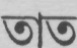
তাত
